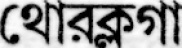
থোরক্লগা
